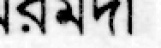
মরমদা
